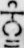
ਨੂੰ
